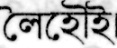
লৈহৌই।
